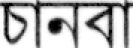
চানবা
